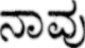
ನಾವು
